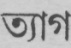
ত্যাগ
